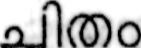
ചിതം
